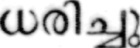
ധരിച്ചു
